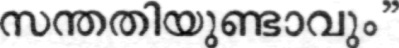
സന്തതിയുണ്ടാവും”
